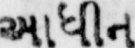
આધીન
